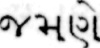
જમણે
